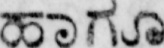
ಹಾಗೂ
